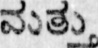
ಮತ್ತು
